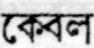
কেবল
